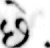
છે.
